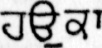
ਹਉਕਾ
